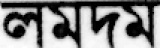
লমদম
